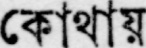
কোথায়
